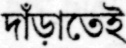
দাঁড়াতেই
